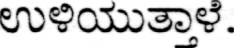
ಉಳಿಯುತ್ತಾಳೆ.
